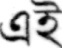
এই
